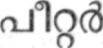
പീറ്റര്‍
